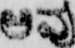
ಅವು
